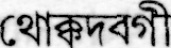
থোক্কদবগী
